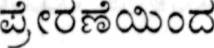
ಪ್ರೇರಣೆಯಿಂದ
